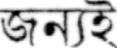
জন্যই
